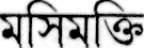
মসিমক্তি
